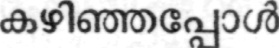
കഴിഞ്ഞപ്പോള്‍
